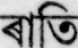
ৰাতি
